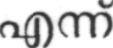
എന്ന്
